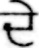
ਦੇ
